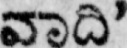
ವಾದಿ’
